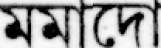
মমাদো
